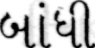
બાંધી
